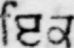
ਇਕ
